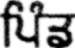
ਪਿੰਡ
